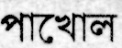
পাখোল
